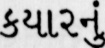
કયારનું
